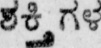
ಶಕ್ತಿಗಳ
